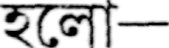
হলো–
